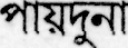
পায়দুনা
